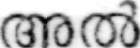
അല്‍
